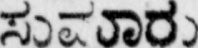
ಸುಮಾರು
